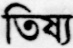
তিষ্য
